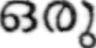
ഒരു
